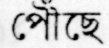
পৌঁছে
